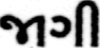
જાગી
